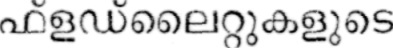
ഫ്ളഡ്ലൈറ്റുകളുടെ
